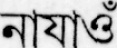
নাযাওঁ
